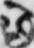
છે
